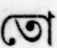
তো
